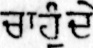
ਚਾਹੁੰਦੇ
